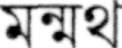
মন্মথ
